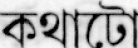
কথাটো
